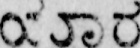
ಯಾರ
